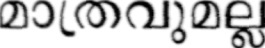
മാത്രവുമല്ല
